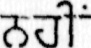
ਨਹੀਂ
